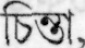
চিন্তা,
